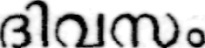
ദിവസം
